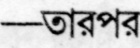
–তারপর
